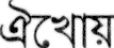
ঐখোয়
